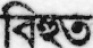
বিহুত
